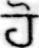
ਹੋ
